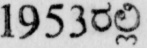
1953ರಲ್ಲಿ
